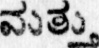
ಮತ್ತು
